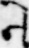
ને
